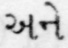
અને
